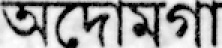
অদোমগা
